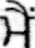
ਮੈਂ
